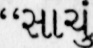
"સાચું
